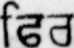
ਫਿਰ
